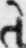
તે
